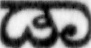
ಡಾ
